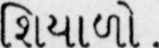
શિયાળો.
